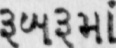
રૂબરૂમાં
